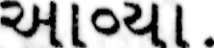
આવ્યા.
